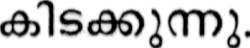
കിടക്കുന്നു.
